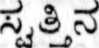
ಸ್ವತ್ತಿನ
